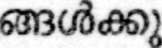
ങ്ങള്‍ക്കു
